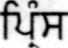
ਪ੍ਰਿੰਸ
